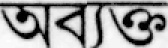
অব্যক্ত
